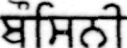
ਬੌਸਿਨੀ
